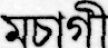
মচাগী
